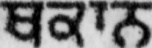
ਥਕਾਨ
